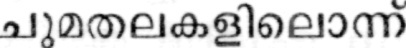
ചുമതലകളിലൊന്ന്
